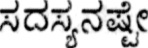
ಸದಸ್ಯನಷ್ಟೇ
